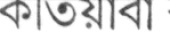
কাতয়াবা
